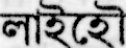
লাইহৌ
